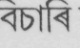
বিচাৰি
